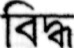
বিদ্ধ
